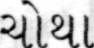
ચોથા
